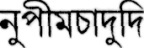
নুপীমচাদুদি
